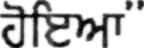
ਹੋਇਆ''
